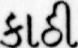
કાઠી
